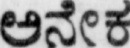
ಅನೇಕ
